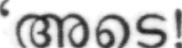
‘അടെ!
